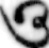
ও
